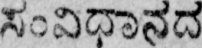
ಸಂವಿಧಾನದ
